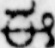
ಈ
